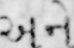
અને
